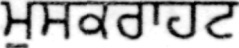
ਮੁਸਕਰਾਹਟ
